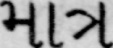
માત્ર
